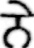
ਨੇ
